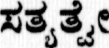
ಸತ್ಯತ್ವೇ
